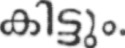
കിട്ടും.
